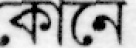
কোনে
